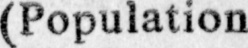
(Population
